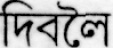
দিবলৈ
